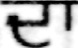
ਦਾ
